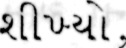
શીખ્યો,
